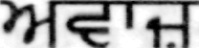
ਅਵਾਜ਼
